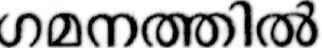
ഗമനത്തില്‍
